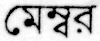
মেম্বর
